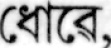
ধোৱে,
